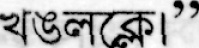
খঙলক্লে।”
